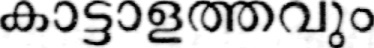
കാട്ടാളത്തവും
